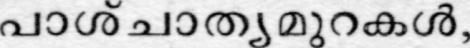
പാശ്ചാത്യമുറകള്‍,
